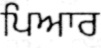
ਪਿਆਰ
